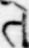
તે
